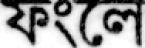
ফংলে
